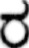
ರ
